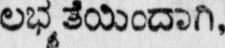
ಲಭ್ಯತೆಯಿಂದಾಗಿ,
